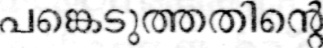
പങ്കെടുത്തതിന്റെ
